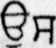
ਉਸ
